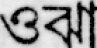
ওঝা
